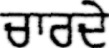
ਚਾਰਦੇ
